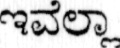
ಇವೆಲ್ಲಾ
